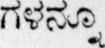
ಗಳನ್ನೂ
